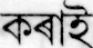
কৰাই
